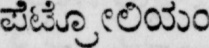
ಪೆಟ್ರೋಲಿಯಂ
